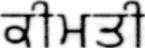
ਕੀਮਤੀ
